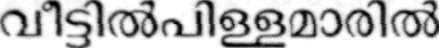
വീട്ടില്‍പിള്ളമാരില്‍
